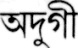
অদুগী
